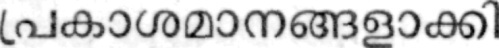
പ്രകാശമാനങ്ങളാക്കി
